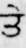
ਤੇ
